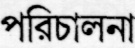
পরিচালনা
